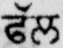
ਫੱਲ
